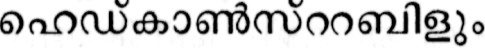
ഹെഡ്കാണ്‍സ്ററബിളും
